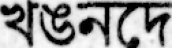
খঙনদে
